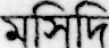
মসিদি
